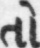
તો
